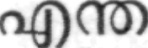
എന്ത
